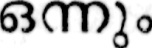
ഒന്നും
